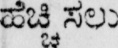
ಹೆಚ್ಚಿಸಲು
